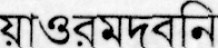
য়াওরমদবনি
